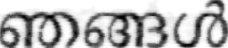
ഞങ്ങള്‍
